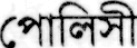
পোলিসী
